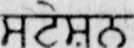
ਸਟੇਸ਼ਨ
